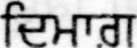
ਦਿਮਾਗ਼
